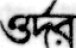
ওর্দর
